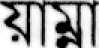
য়াম্না
